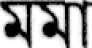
মমা
